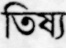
তিষ্য
